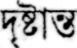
দৃষ্টান্ত
